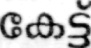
കേട്ട്
